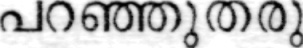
പറഞ്ഞുതരു
